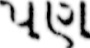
પણ
